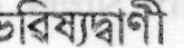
ভৱিষ্যদ্বাণী
